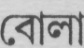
বোলা
